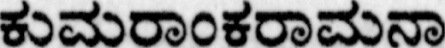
ಕುಮರಾಂಕರಾಮನಾ
